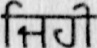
ਜਿਹੀ
